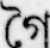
গৈ
